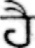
ਹੈ
